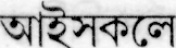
আইসকলে
